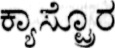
ಕ್ಯಾಸ್ಟ್ರೊರ
